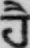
ਹੈ
